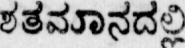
ಶತಮಾನದಲ್ಲಿ
